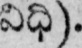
ವಿಧಿ).
